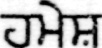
ਹਮੇਸ਼
